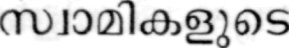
സ്വാമികളുടെ
